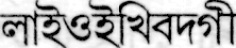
লাওইইখিবদগী
